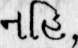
નહિ,
